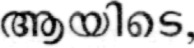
ആയിടെ,
